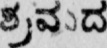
ಶ್ರಮದ
